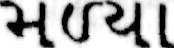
મળ્યા
